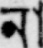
না
